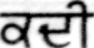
ਕਦੀ
